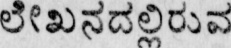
ಲೇಖನದಲ್ಲಿರುವ
